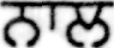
ਨਾਲ
